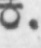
ಕೆ.
